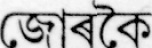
জোৰকৈ
